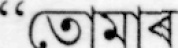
"তোমাৰ
